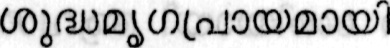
ശുദ്ധമൃഗപ്രായമായി
